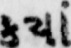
ક્યાં
